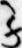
કે
